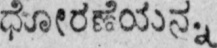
ಧೋರಣೆಯನ್ನು
